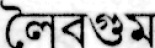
লৈবগুম
